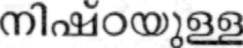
നിഷ്ഠയുള്ള
